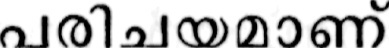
പരിചയമാണ്
